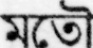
মতৌ
